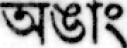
অঙাং
